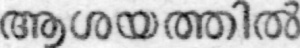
ആശയത്തില്‍
